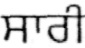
ਸਾਰੀ
